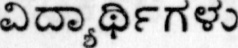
ವಿದ್ಯಾರ್ಥಿಗಳು
